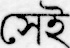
সেই
